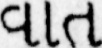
વાત
